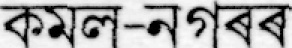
কমল-নগৰৰ
